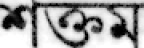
শক্তম
